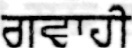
ਗਵਾਹੀ
